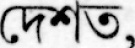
দেশত,
